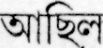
আছিল
